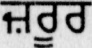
ਜ਼ਰੂਰ
